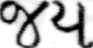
જય
